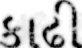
કાઢી
